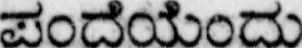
ಪಂದೆಯೆಂದು
